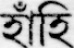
হাঁহি
